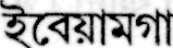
ইবেয়াইমগা
